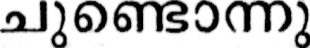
ചുണ്ടൊന്നു
